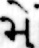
મેં
